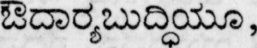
ಔದಾರ್‍ಯಬುದ್ಧಿಯೂ,
